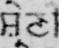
ਸ਼੍ਰੇਣੀ
